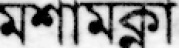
মশামক্না
